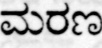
ಮರಣ
